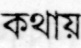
কথায়
